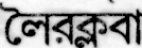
লৈরক্লবা
